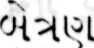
બેત્રણ
